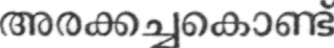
അരക്കച്ചകൊണ്ട്
